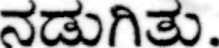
ನಡುಗಿತು.
